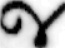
જ
